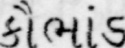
કૌભાંડ
